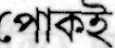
পোকই
